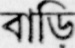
বাড়ি
